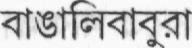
বাঙালিবাবুরা
